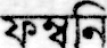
ফম্বনি
